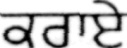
ਕਰਾਏ
